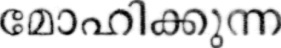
മോഹിക്കുന്ന
